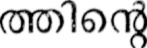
ത്തിന്റെ
